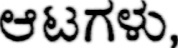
ಆಟಗಳು,
